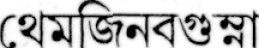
থেমজিনবগুম্না
